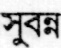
সুবন্ন
